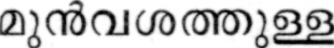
മുന്‍വശത്തുള്ള
